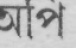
অপি
